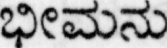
ಭೀಮನು
